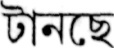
টানছে
